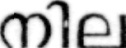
നില
